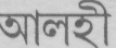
আলহী
